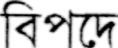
বিপদে
